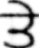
ਤੇ
